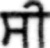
ਸੀ
